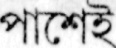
পাশেই
